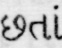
છતાં
